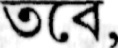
তবে,
